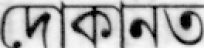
দোকানত
